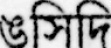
ঙসিদি
